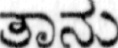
ತಾನು
